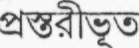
প্রস্তরীভূত
